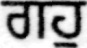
ਗਹੁ
